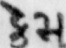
કેમ
